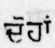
ਦੋਹਾਂ
